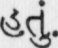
હતું.
